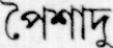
লৈশাদু
